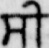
ਸੀ
